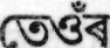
তেওঁৰ
